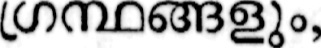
ഗ്രന്ഥങ്ങളും,
